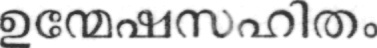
ഉന്മേഷസഹിതം
